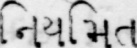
નિયમિત
